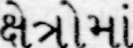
ક્ષેત્રોમાં
